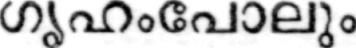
ഗൃഹംപോലും
